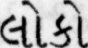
લોકો
